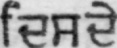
ਦਿਸਦੇ
